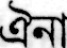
ঐনা
